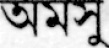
অমসু
